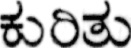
ಕುರಿತು
